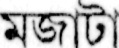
মজাটা
